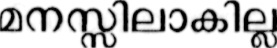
മനസ്സിലാകില്ല
